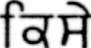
ਕਿਸੇ
